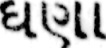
ઘણા
